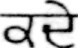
ਕਦੇ
